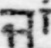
ਜਾਂ
